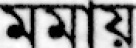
মমায়
